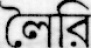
লৈরি
